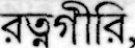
রত্নগীরি,
